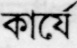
কার্যে
